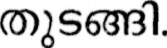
തുടങ്ങി.
